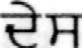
ਦੇਸ
